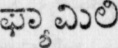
ಫ್ಯಾಮಿಲಿ
